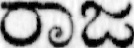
ರಾಜ
